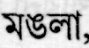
মঙলা,
